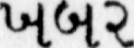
ખબર
